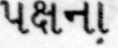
પક્ષના
